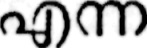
എന്ന
